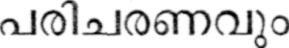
പരിചരണവും
